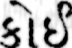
કોઈ
